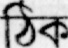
ঠিক
